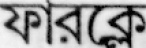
ফারক্লে
